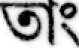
তাং
